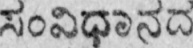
ಸಂವಿಧಾನದ
